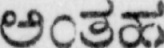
ಅಂತಹ
